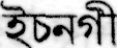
ইচনগী
